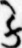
કે
